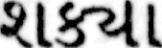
શક્યા
